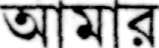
আমার
